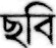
ছবি
